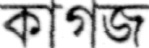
কাগজ
